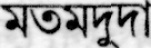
মতমদুদা
